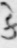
કે
